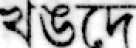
খঙদে
